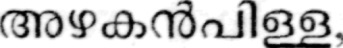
അഴകന്‍പിള്ള,
